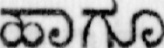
ಹಾಗೂ
